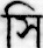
সি
